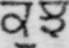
ਕੁਝ
